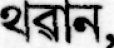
থৱান,
